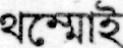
থম্মোই
